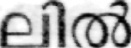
ലില്‍
